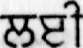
ਲਈ
